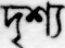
দৃশ্য
